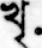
খৃ.
